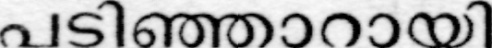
പടിഞ്ഞാറായി
